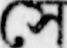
সে
